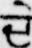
ਦੇ
